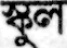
স্কুল
